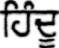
ਹਿੰਦੂ
